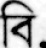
বি.
